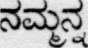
ನಮ್ಮನ್ನ
